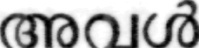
അവള്‍
